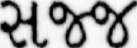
સજ્જ
